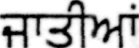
ਜਾਤੀਆਂ
